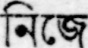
নিজে
